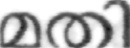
മതി
